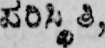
ಪರಿಸ್ಥಿತಿ,
